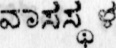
ವಾಸಸ್ಥಳ
